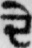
ਦੇ
